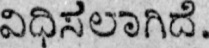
ವಿಧಿಸಲಾಗಿದೆ.
